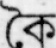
কৈ
